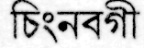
চিংনবগী
